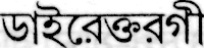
ডাইরেক্তরগী
